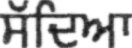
ਸੱਦਿਆ
